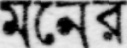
মনের
